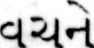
વચને
